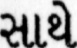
સાથે
